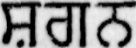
ਸ਼ਗਨ
